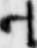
ન
